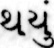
થયું
